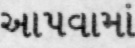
આપવામાં
